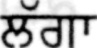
ਲੱਗਾ
